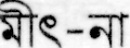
মীৎ-না
